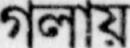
গলায়
